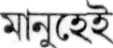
মানুহেই
